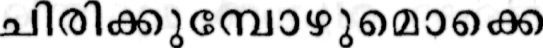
ചിരിക്കുമ്പോഴുമൊക്കെ
